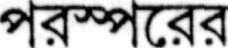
পরস্পরের
